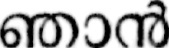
ഞാന്‍
